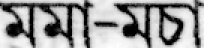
মমা-মচা
